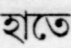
হাতে
